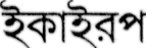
ইকাইরপ
